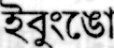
ইবুংঙো
